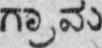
ಗ್ರಾಮ
